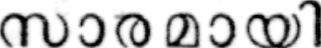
സാരമായി
